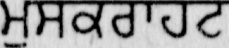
ਮੁਸਕਰਾਹਟ
